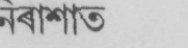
নিৰাশাত
